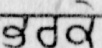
ਭਰਕੇ
